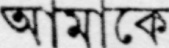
আমাকে
